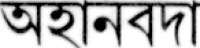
অহানবা
